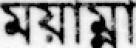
ময়াম্না
